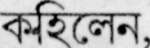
কহিলেন,
